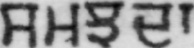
ਸਮਝਦਾ
